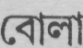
বোলা
